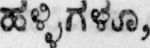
ಹಳ್ಳಿಗಳೂ,
